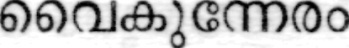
വൈകുന്നേരം
